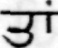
ਤਾਂ
